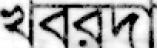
খবরদা
